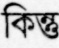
কিন্তু
